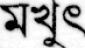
মখুৎ
